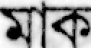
মাক
